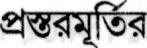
প্রস্তরমূর্তির
